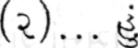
(૨)...હું
